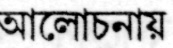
আলোচনায়
